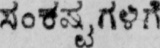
ಸಂಕಷ್ಟಗಳಿಗೆ
